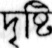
দৃষ্টি
